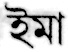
ইমা
